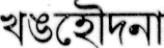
খঙহৌদনা
